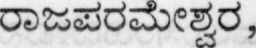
ರಾಜಪರಮೇಶ್ವರ,
